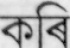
কৰি
